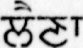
ਲੈਣਾ
